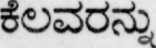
ಕೆಲವರನ್ನು
